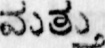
ಮತ್ತು
